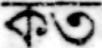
কত
